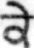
ਕੇ
